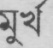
মুৰ্খ
